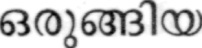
ഒരുങ്ങിയ
